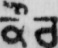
ਕੌਰ
